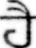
ਹੈ
